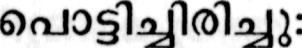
പൊട്ടിച്ചിരിച്ചു:
